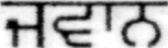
ਜਵਾਨ
